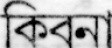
কিবনা
